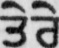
ਤੇਰੇ
